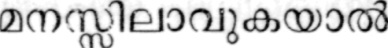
മനസ്സിലാവുകയാല്‍
